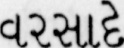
વરસાદે
